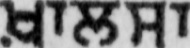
ਖ਼ਾਲਸਾ
